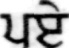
ਪਏ
